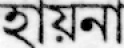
হায়না
